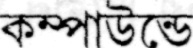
কম্পাউন্ডে
